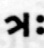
ત્રઃ
